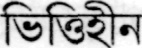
ভিত্তিহীন
